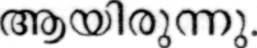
ആയിരുന്നു.
